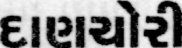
દાણચોરી
